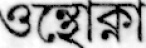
ওন্থোক্না
